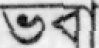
ভবা
